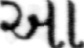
આ
